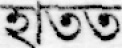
হাতত
